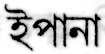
ইপানা
